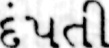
દંપતી
